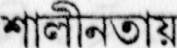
শালীনতায়
